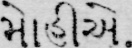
મોહીએ.
